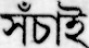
সঁচাই
